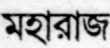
মহারাজ
